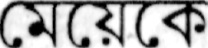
মেয়েকে
